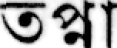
তপ্না
